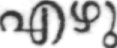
എഴു
